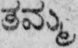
ತಮ್ಮ
